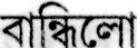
বান্ধিলো
